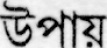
উপায়
